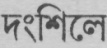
দংশিলে
